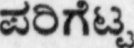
ಪರಿಗೆಟ್ಟ
